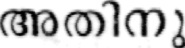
അതിനു
